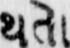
થતો
